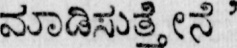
ಮಾಡಿಸುತ್ತೇನೆ’
